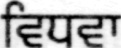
ਵਿਧਵਾ
